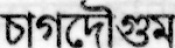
চাগদৌগুম
